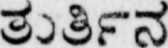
ತುರ್ತಿನ
